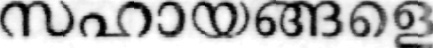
സഹായങ്ങളെ
